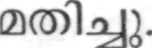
മതിച്ചു.
